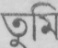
তুমি
